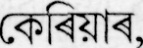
কেৰিয়াৰ,
